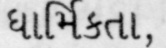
ધાર્મિકતા,
